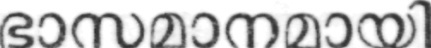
ഭാസമാനമായി
